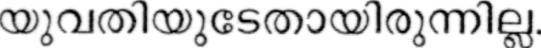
യുവതിയുടേതായിരുന്നില്ല.
